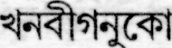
খনবীগনুকো
